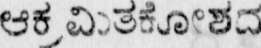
ಆಕ್ರಮಿತಕೋಶದ
